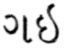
ગઈ
